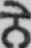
ਨੇ
